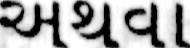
અથવા
